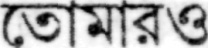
তোমারও
